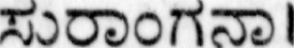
ಸುರಾಂಗನಾ|
